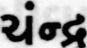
ચંન્દ્ર
